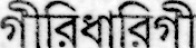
গীরিধারিগী
